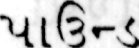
પાઉન્ડ
